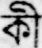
কী
